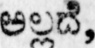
ಅಲ್ಲದೆ,
